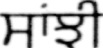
ਸਾਂਝੀ
